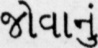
જોવાનું
